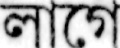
লাগে
